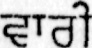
ਵਾਰੀ
